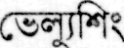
ভেল্যুশিং
